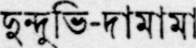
দুন্দুভি-দামামা
